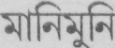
মানিমুনি
